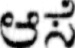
ಆಸೆ
